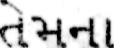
તેમના
